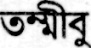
তম্মীবু
